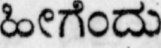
ಹೀಗೆಂದು
